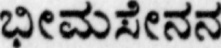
ಭೀಮಸೇನನ
